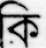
কি
